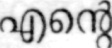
എന്റെ
